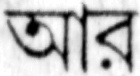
আর
